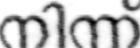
നിന്ന്
